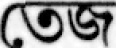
তেজ
